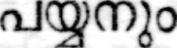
പയ്യനും
